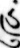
હું
